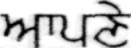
ਆਪਣੇ
